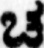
ಚ
